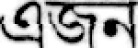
এজন
